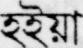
হইয়া
